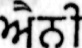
ਐਨੀ
